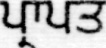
ਪ੍ਰਾਪਤ
